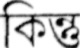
কিন্তু
